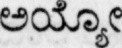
ಅಯ್ಯೋ
